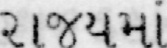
રાજ્યમાં
